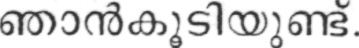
ഞാന്‍കൂടിയുണ്ട്.
